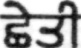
ਛੇਤੀ
